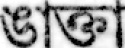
ঙাক্তা
